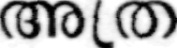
അത്ര
